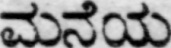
ಮನೆಯ
